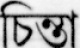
চিন্তা
